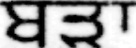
ਬੜਾ
